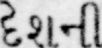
દેશની
